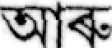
আৰু
